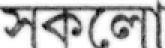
সকলো
